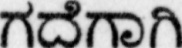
ಗದೆಗಾಗಿ
